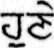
ਹੁਣੇ
